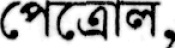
পেত্রোল,
